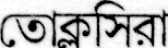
তোক্লসিরা
